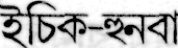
ইচিক-হুনবা
